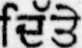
ਦਿੱਤੇ
